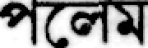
পলেম
